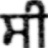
ਸੀ
